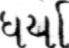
ધર્યા
